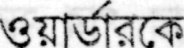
ওয়ার্ডারকে
